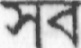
সব
